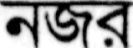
নজর
